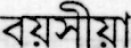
বয়সীয়া
